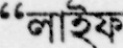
“লাইফ
